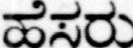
ಹೆಸರು
